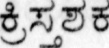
ಕ್ರಿಸ್ತಶಕ
